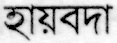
হায়বদা
